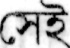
সেই
